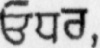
ਓਧਰ,
